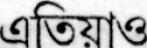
এতিয়াও
